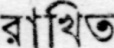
রাখিত
